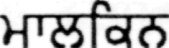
ਮਾਲਕਿਨ
